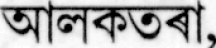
আলকতৰা,
